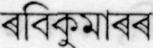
ৰবিকুমাৰৰ
